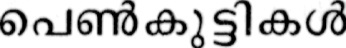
പെണ്‍കുട്ടികള്‍
